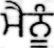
ਮੈਨੂੰ
